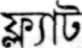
ফ্ল্যাট
